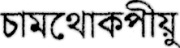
চামথোকপীয়ু
